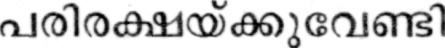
പരിരക്ഷയ്ക്കുവേണ്ടി
